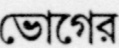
ভোগের
